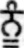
ਨੂੰ
